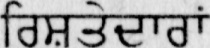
ਰਿਸ਼ਤੇਦਾਰਾਂ
